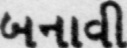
બનાવી
